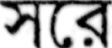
সরে
